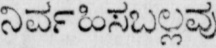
ನಿರ್ವಹಿಸಬಲ್ಲವು
